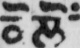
ਕੋਲੋਂ
